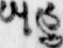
બહુ
